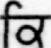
ਕਿ
